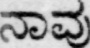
ನಾವು
